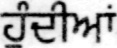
ਹੁੰਦੀਆਂ
